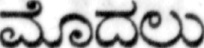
ಮೊದಲು
